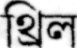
থ্রিল
